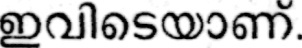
ഇവിടെയാണ്.
